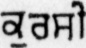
ਕੁਰਸੀ
